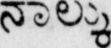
ನಾಲ್ಕು
